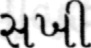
સખી
